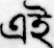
এই
